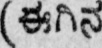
(ಈಗಿನ
